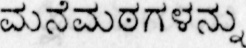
ಮನೆಮಠಗಳನ್ನು
